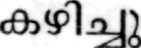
കഴിച്ചു
